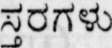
ಸ್ತರಗಳು
